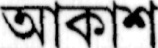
আকাশ
